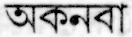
অকনবা
